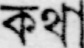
কথা
